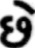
છે
